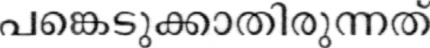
പങ്കെടുക്കാതിരുന്നത്
